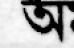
অ
